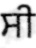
ਸੀ
